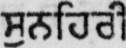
ਸੁਨਹਿਰੀ
